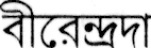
বীরেন্দ্রদা
